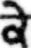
ਕੇ
